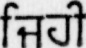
ਜਿਹੀ
